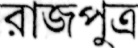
রাজপুত্র
